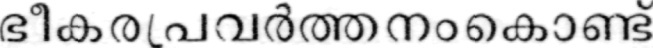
ഭീകരപ്രവര്‍ത്തനംകൊണ്ട്
